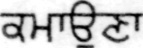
ਕਮਾਉਣਾ
